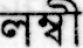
লম্বী
